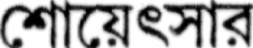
শোয়েৎসার
